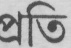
প্ৰতি
